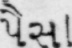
પૈસા
